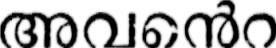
അവന്റെ
